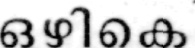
ഒഴികെ
